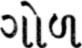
ગોળ
